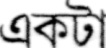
একটা
